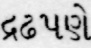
દ્રઢપણે
